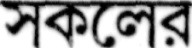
সকলের
